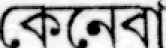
কেনেবা
